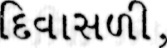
દિવાસળી,
